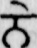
ਨੇ
